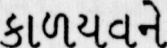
કાળયવને
